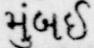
મુંબઈ
